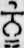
ਨੂੰ
